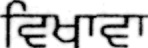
ਵਿਖਾਵਾ
